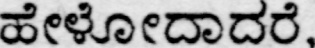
ಹೇಳೋದಾದರೆ,
